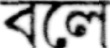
বলে
